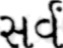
સર્વં
